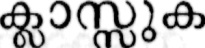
ക്ലാസ്സുക
